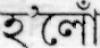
হ'লোঁ
